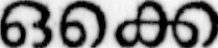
ഒക്കെ
